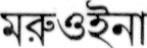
মরুওইনা
